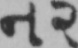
નર
